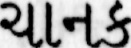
ચાનક
